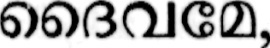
ദൈവമേ,
